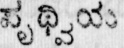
ಪೃಥ್ವಿಯ
